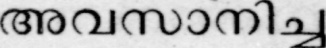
അവസാനിച്ച
